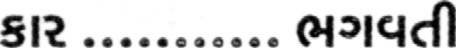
કાર..........ભગવતી
